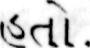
હતો.
